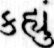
કહ્યું
